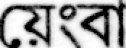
য়েংবা
